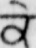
ਕੇ
